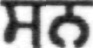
ਸਨ
